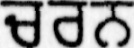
ਚਰਨ
